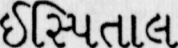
ઈસ્પિતાલ
